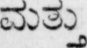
ಮತ್ತು
